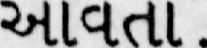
આવતા.
